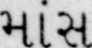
માંસ
